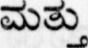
ಮತ್ತು
